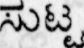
ಸುಟ್ಟ
